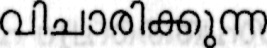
വിചാരിക്കുന്ന
